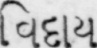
વિદાય
